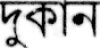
দুকান
